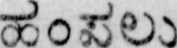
ಹಂಪಲು
